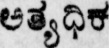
ಅತ್ಯಧಿಕ
